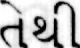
તેથી
